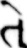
તે
